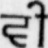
ਵੀ
